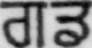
ਗਡ
